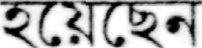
হয়েছেন
